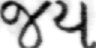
જય
